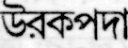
উরকপদা
